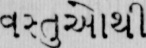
વસ્તુઓથી
